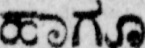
ಹಾಗೂ
